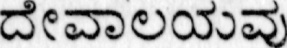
ದೇವಾಲಯವು
